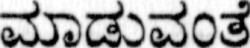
ಮಾಡುವಂತೆ
